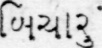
બિચારું
